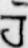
ਹੋ
